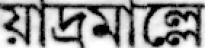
য়াদ্রমাল্লে
